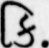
કિ.
